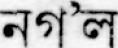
নগ'ল
